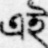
এই
